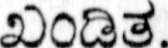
ಖಂಡಿತ.
